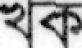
খক
